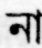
না
